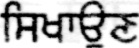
ਸਿਖਾਉਣ
